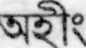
অহীং
